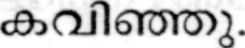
കവിഞ്ഞു.
